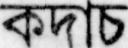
কদাচ
